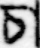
চা
